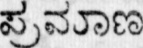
ಪ್ರಮಾಣ
